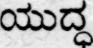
ಯುದ್ದ
